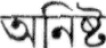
অনিষ্ট
